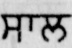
ਸਾਲ
